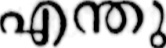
എന്തു
